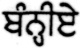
ਬੰਨ੍ਹੀਏ
